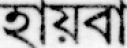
হায়বা
